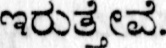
ಇರುತ್ತೇವೆ.
